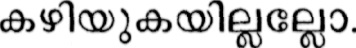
കഴിയുകയില്ലല്ലോ.
